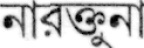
নারক্তুনা
